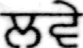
ਲਵੇ
